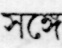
সঙ্গে
